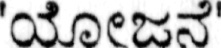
‘ಯೋಜನೆ’
